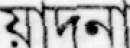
য়াদনা
